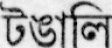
টঙালি
